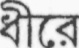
ধীরে
